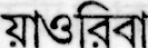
য়াওরিবা
